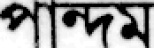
পান্দম
